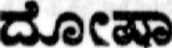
ದೋಷಾ
